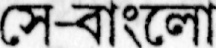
সে-বাংলো
